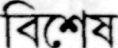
বিশেষ
